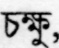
চক্ষু,
